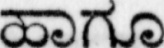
ಹಾಗೂ
